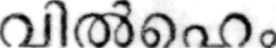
വില്‍ഹെം
